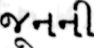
જૂનની
